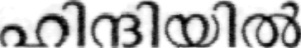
ഹിന്ദിയില്‍
